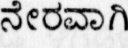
ನೇರವಾಗಿ
